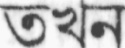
তখন
